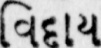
વિદાય
